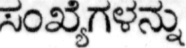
ಸಂಖ್ಯೆಗಳನ್ನು
